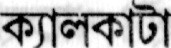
ক্যালকাটা
